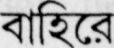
বাহিরে
